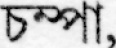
চম্পা,
